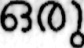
ഒരു
